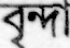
বৃন্দা
